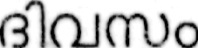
ദിവസം
